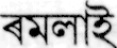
ৰমলাই
